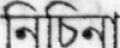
নিচিনা
